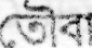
তৌবা
